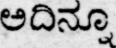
ಅದಿನ್ನೂ
